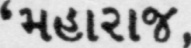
'મહારાજ,
